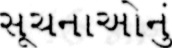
સૂચનાઓનું
